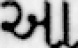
આ
